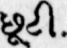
છૂટી.
